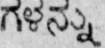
ಗಳನ್ನು
